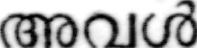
അവള്‍
